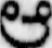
ಆ
